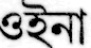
ওইনা
